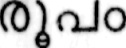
രൂപം
